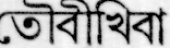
তৌবীখিবা
